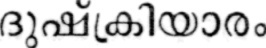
ദുഷ്ക്രിയാരം
